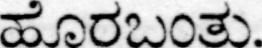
ಹೊರಬಂತು.
